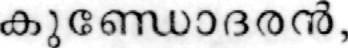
കുണ്ഡോദരന്‍,
